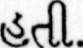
હતી.
